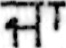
ਜਾ
